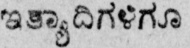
ಇತ್ಯಾದಿಗಳಿಗೂ
